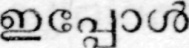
ഇപ്പോള്‍
